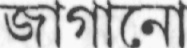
জাগানো
